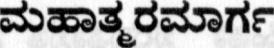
ಮಹಾತ್ಮರಮಾರ್ಗ
